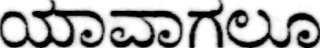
ಯಾವಾಗಲೂ
